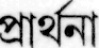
প্রার্থনা
